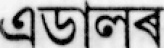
এডালৰ
